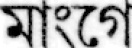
মাংগে
